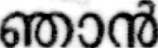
ഞാന്‍
